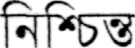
নিশ্চিন্ত
